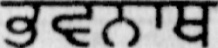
ਭਵਨਾਥ
